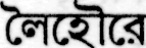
লৈহৌরে
